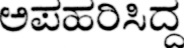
ಅಪಹರಿಸಿದ್ದ
